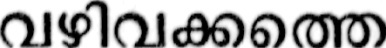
വഴിവക്കത്തെ
